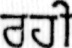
ਰਹੀ
